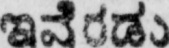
ಇವೆರಡು
